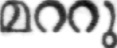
മററു
